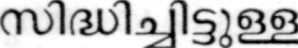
സിദ്ധിച്ചിട്ടുള്ള
